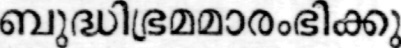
ബുദ്ധിഭ്രമമാരംഭിക്കു
